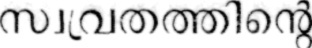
സ്വവ്രതത്തിന്റെ
